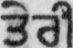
ਤੇਰੀ
